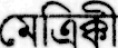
মেত্রিক্কী
